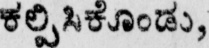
ಕಲ್ಪಿಸಿಕೊಂಡು,
